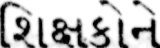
શિક્ષકોને
